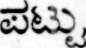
ಪಟ್ಟು
